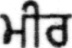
ਮੀਰ
